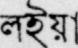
লইয়া
